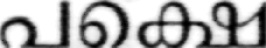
പക്ഷെ
